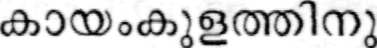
കായംകുളത്തിനു
